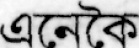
এনেকৈ
